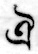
ঐ
